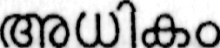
അധികം
